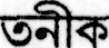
তনীক
